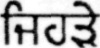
ਜਿਹੜੇ
